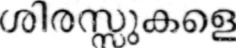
ശിരസ്സുകളെ
